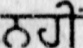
ਨਹੀਂ
